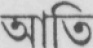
আতি
